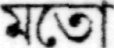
মতো
